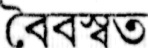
বৈবস্বত
